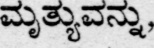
ಮೃತ್ಯುವನ್ನು,
